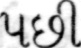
પછી
